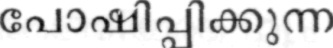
പോഷിപ്പിക്കുന്ന
